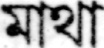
মাথা
